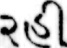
રહી
